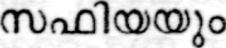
സഫിയയും
